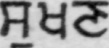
ਸੁਖਣ
